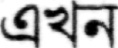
এখন
